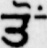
ਤੋਂ
